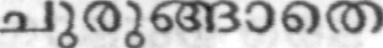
ചുരുങ്ങാതെ
